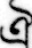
ঐ
